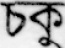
চকু
